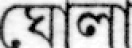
ঘোলা
